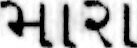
મારા
